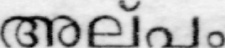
അല്പം
